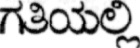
ಗತಿಯಲ್ಲಿ
